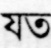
যত
